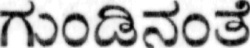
ಗುಂಡಿನಂತೆ
